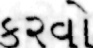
કરવો
